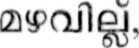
മഴവില്ല്,
